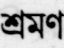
শ্রমণ
